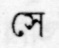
সে
